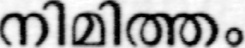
നിമിത്തം
